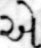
એ
